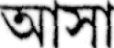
আসা
